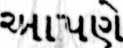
આપણે
